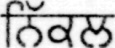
ਨਿੱਕਲ
